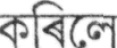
কৰিলে
